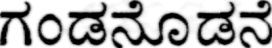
ಗಂಡನೊಡನೆ
